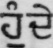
ਹੁੰਦੇ
